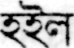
হইল
